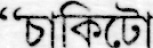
"চাকিটো
